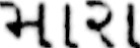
મારા
